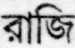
রাজি
